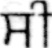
ਸੀ
